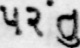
પરંતુ
